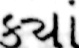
ક્યાં
